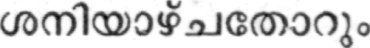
ശനിയാഴ്ചതോറും
